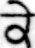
ਕੇ
